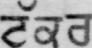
ਟੱਕਰ
